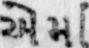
એમાં
